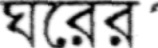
ঘরের
